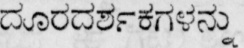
ದೂರದರ್ಶಕಗಳನ್ನು
